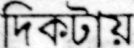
দিকটায়
